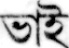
ভাই
